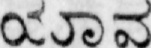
ಯಾವ
